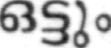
ഒട്ടും
